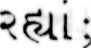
રહ્યાં;
